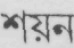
শয়ন
